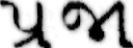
પ્રજા
